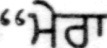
''ਮੇਰਾ
